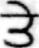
ਤੇ
